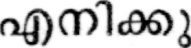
എനിക്കു
